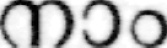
നാം
